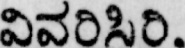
ವಿವರಿಸಿರಿ.
